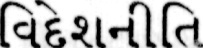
વિદેશનીતિ
